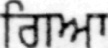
ਗਿਆ
